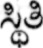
ಸ್ಥಿತಿ
